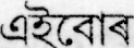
এইবোৰ
